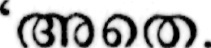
‘അതെ.
